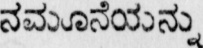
ನಮೂನೆಯನ್ನು
